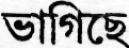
ভাগিছে
